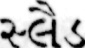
સ્લૈડ
